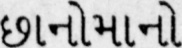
છાનોમાનો
